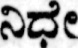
ನಿಧೇ
